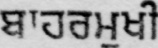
ਬਾਹਰਮੁਖੀ
